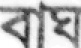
বাঘ
